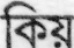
কিয়
